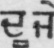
ਦੂਜੇ
